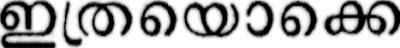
ഇത്രയൊക്കെ
